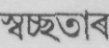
স্বচ্ছতাৰ
